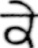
ਕੇ
